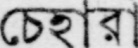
চেহারা
